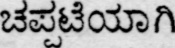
ಚಪ್ಪಟೆಯಾಗಿ
